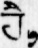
ਹੈ,
